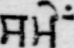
ਸਮੇਂ
